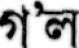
গ'ল
